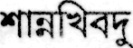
শান্নখিবদু
